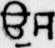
ਉਸ
